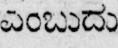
ಎಂಬುದು
